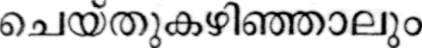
ചെയ്തുകഴിഞ്ഞാലും
